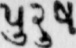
પુરુષ
